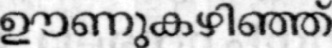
ഊണുകഴിഞ്ഞ്
